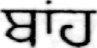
ਬਾਂਹ
